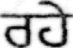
ਰਹੇ
